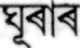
ঘূৰাৰ
